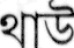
থাউ
